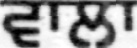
ਵਾਲਾ
